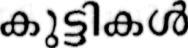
കുട്ടികള്‍
